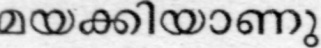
മയക്കിയാണു
